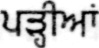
ਪੜ੍ਹੀਆਂ
